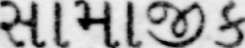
સામાજીક
